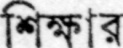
শিক্ষার
